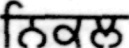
ਨਿਕਲ
